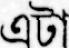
এটা
